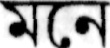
মনে
